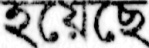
হয়েছে
